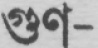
গুণ-
